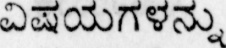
ವಿಷಯಗಳನ್ನು
